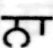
ਨਾ
